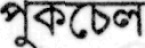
পুকচেল
